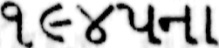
૧૯૪૫ના
